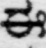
ಈ
